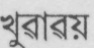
খুৱাৱয়
